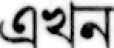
এখন
